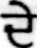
ਦੇ
